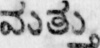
ಮತ್ತು
